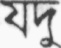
যদু
